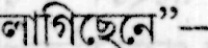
লাগিছেনে"-
